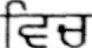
ਵਿਚ
